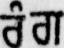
ਰੰਗ
